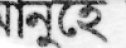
মানুহে
